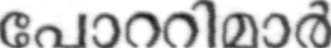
പോററിമാര്‍
